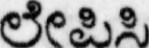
ಲೇಪಿಸಿ
